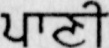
ਪਾਣੀ
